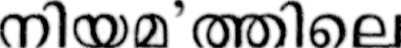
നിയമ’ത്തിലെ
